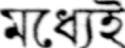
মধ্যেই
